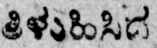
ತಿಳುಹಿಸಿದ
